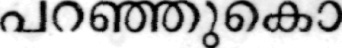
പറഞ്ഞുകൊ
